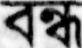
বন্ধ
